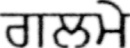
ਗਲਮੇ
